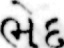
ભેદ
